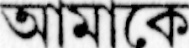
আমাকে
